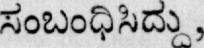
ಸಂಬಂಧಿಸಿದ್ದು,
